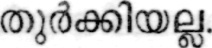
തുര്‍ക്കിയല്ല.
